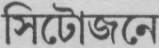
সিটোজনে
